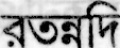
রতন্নদি
